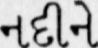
નદીને
